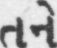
તને
